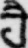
ਹੈ
